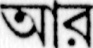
আর
